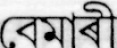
বেমাৰী
